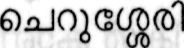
ചെറുശ്ശേരി
